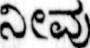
ನೀವು
